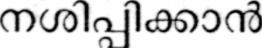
നശിപ്പിക്കാന്‍
